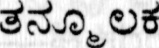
ತನ್ಮೂಲಕ
